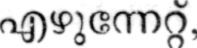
എഴുന്നേറ്റ്,
